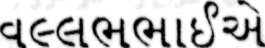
વલ્લભભાઈએ
